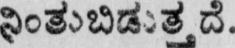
ನಿಂತುಬಿಡುತ್ತದೆ.
